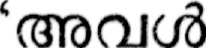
'അവള്‍
